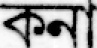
কনা
